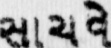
સાચવે
